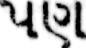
પણ
